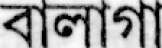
বালাগা
